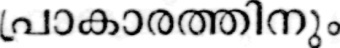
പ്രാകാരത്തിനും
